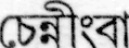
চেন্নীংবা
